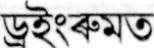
ড্ৰইংৰুমত
